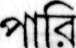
পারি
